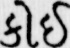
કોઈ
